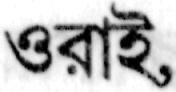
ওরাই,
